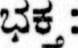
ಭಕ್ತ:
